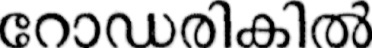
റോഡരികില്‍
